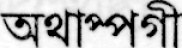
অথাপ্পগী
